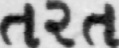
તરત
